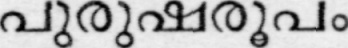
പുരുഷരൂപം
